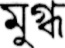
মুগ্ধ
